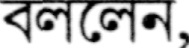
বললেন,
